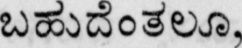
ಬಹುದೆಂತಲೂ,
